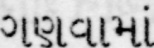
ગણવામાં
